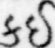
કઈ
